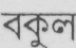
বকুল
